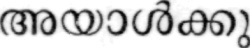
അയാള്‍ക്കു
